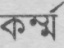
কৰ্ম্ম
